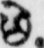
છે.
